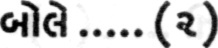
બોલે...........(૨)
